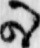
જે
